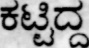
ಕಟ್ಟಿದ್ದ
